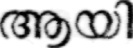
ആയി
